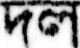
দল
